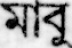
মাবু
